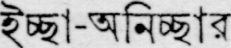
ইচ্ছা-অনিচ্ছার
